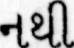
નથી
